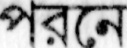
পরনে
